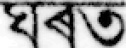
ঘৰত
